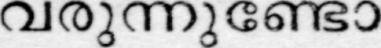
വരുന്നുണ്ടോ
